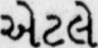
એટલે
